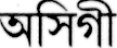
অসিগী
